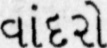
વાંદરો
